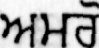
ਅਮਰੋ
